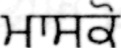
ਮਾਸਕੋ
